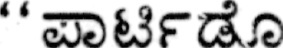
"ಪಾರ್ಟಿಡೊ
